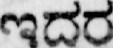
ಇದರ
